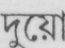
দুয়ো
